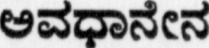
ಅವಧಾನೇನ
